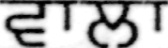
ਵਾਲਾ
